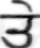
ਤੇ
